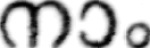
നാം
